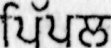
ਪਿੱਪਲ
